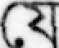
যে
